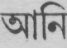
আনি
